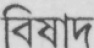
বিষাদ
